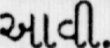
આવી.
